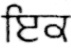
ਇਕ
